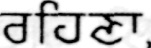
ਰਹਿਣਾ,
